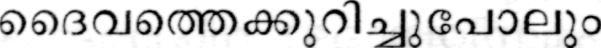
ദൈവത്തെക്കുറിച്ചുപോലും
